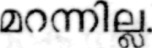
മറന്നില്ല.
